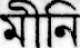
মীনি
